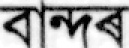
বান্দৰ
